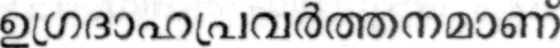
ഉഗ്രദാഹപ്രവര്‍ത്തനമാണ്
